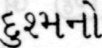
દુશ્મનો
